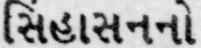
સિંહાસનનો
